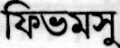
ফিভমসু
